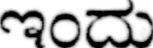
ಇಂದು
